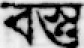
বস্তু
